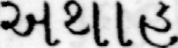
અથાહ
